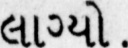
લાગ્યો.
